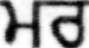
ਮਰ
